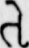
તે
